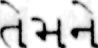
તેમને
